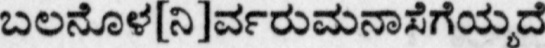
ಬಲನೊಳ[ನಿ]ರ್ವರುಮನಾಸೆಗೆಯ್ಯದೆ
